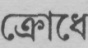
ক্ৰোধে
